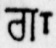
ਗਾ
